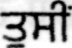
ਤੁਸੀਂ
